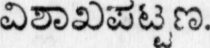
ವಿಶಾಖಪಟ್ಟಣ.
